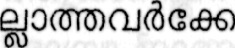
ല്ലാത്തവര്‍ക്കേ
